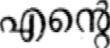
എന്റെ
